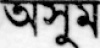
অসুম
